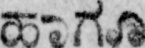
ಹಾಗೂ
